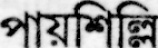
পায়শিল্লি
